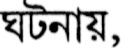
ঘটনায়,
